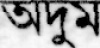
অদুম
